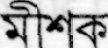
মীশক
